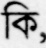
কি,
